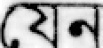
যেন
